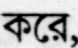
করে,
